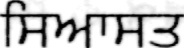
ਸਿਆਸਤ
